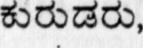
ಕುರುಡರು,
